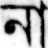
না
